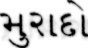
મુરાદો
